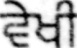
ਵੇਖੀ
